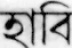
হাবি
